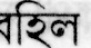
বহিল
